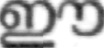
ഈ
